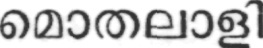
മൊതലാളി
